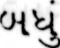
બધું
